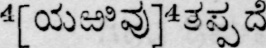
4[ಯಱಿವು]4ತಪ್ಪದೆ
